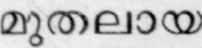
മുതലായ
